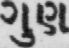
ગુણ
